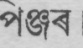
পিঞ্জৰ
